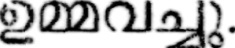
ഉമ്മവച്ചു.
